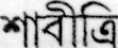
শাবীত্রি
